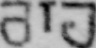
ਰਾਹ
